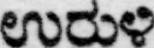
ಉರುಳಿ
